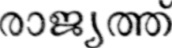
രാജ്യത്ത്
